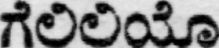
ಗೆಲಿಲಿಯೊ
